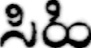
ಸಿಹಿ
